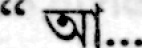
“আ...
